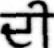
ਦੀ
